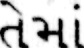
તેમાં
